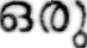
ഒരു
